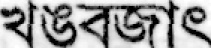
খঙবজাৎ
